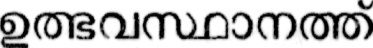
ഉത്ഭവസ്ഥാനത്ത്
